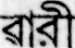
ৱারী
